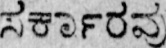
ಸರ್ಕಾರವು
